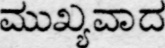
ಮುಖ್ಯವಾದ
